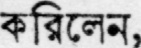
করিলেন,
